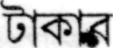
টাকার
